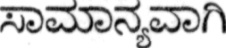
ಸಾಮಾನ್ಯವಾಗಿ
